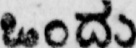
ಒ೦ದು
